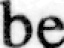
be
